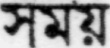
সময়
